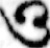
ও
